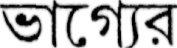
ভাগ্যের
